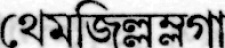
থেমজিল্লম্লগা
